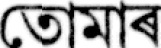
তোমাৰ
